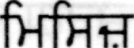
ਮਿਸਿਜ਼
